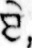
ਏ,
